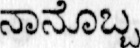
ನಾನೊಬ್ಬ
